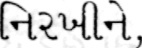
નિરખીને,
